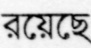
রয়েছে
